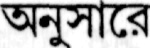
অনুসারে
